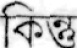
কিন্তু
